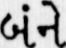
બંને
